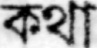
কথা
